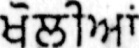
ਖੋਲੀਆਂ
